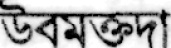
উবমক্তদা
